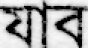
যাব
